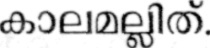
കാലമല്ലിത്.
